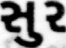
સુર
